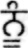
ਨੂੰ
